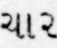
ચાર
